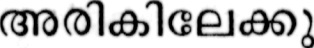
അരികിലേക്കു
